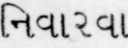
નિવારવા
